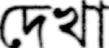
দেখা
